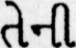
તેની
